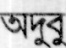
অদুবু
